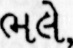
ભલે,
